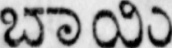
ಬಾಯಿ
